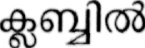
ക്ലബ്ബില്‍
